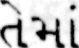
તેમાં
